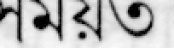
সময়ত
